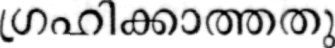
ഗ്രഹിക്കാത്തതു
